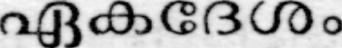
ഏകദേശം
